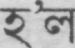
হ'ল
